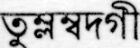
তুম্লম্বদগী
